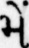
મેં
